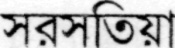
সরসতিয়া
